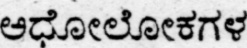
ಅಧೋಲೋಕಗಳ
